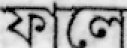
ফালে
